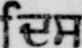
ਦਿਸ
